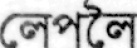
লেপলৈ
